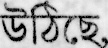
উঠিছে,
